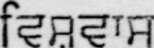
ਵਿਸ਼ਵਾਸ
